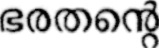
ഭരതന്റെ
